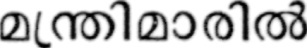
മന്ത്രിമാരില്‍
